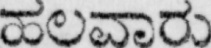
ಹಲವಾರು
